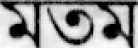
মতম
